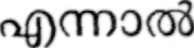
എന്നാല്‍
